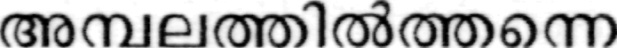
അമ്പലത്തില്‍ത്തന്നെ
